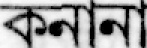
কনানা
